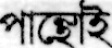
পান্থোই
